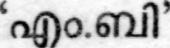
'എം.ബി.'
